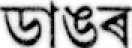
ডাঙৰ
